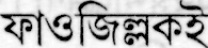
ফাওজিল্লকই
